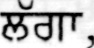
ਲੱਗਾ,
